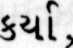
કર્યા,
